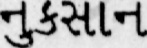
નુકસાન
